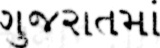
ગુજરાતમાં
